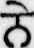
ਨੇ
